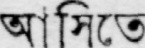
আসিতে
